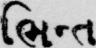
ભિન્ત
